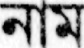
নাম
